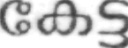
കേട്ട
